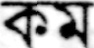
কম
